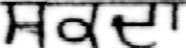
ਸਕਦਾ
